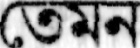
তেমন
